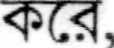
করে,
